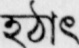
হঠাৎ
